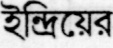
ইন্দ্রিয়ের
